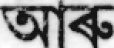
আৰু
